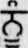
ਨੂੰ
